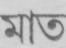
মাত
